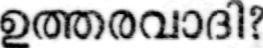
ഉത്തരവാദി?
